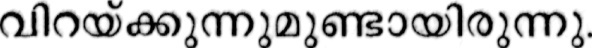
വിറയ്ക്കുന്നുമുണ്ടായിരുന്നു.
